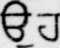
ਉਹ
